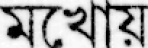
মখোয়
